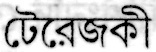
টেরেজকী
